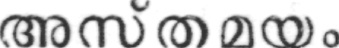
അസ്തമയം
